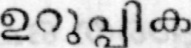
ഉറുപ്പിക
